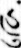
હું
